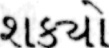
શક્યો
